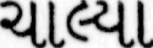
ચાલ્યા
